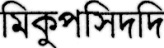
মিকুপসিদদি
